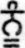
ਨੂੰ
